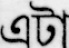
এটা
